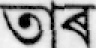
তাৰ
